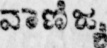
ವಾಣಿಜ್ಯ
